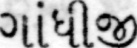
ગાંધીજી
